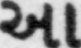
આ
